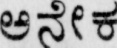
ಅನೇಕ
